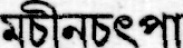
মচীনচৎপা
